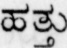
ಹತ್ತು
